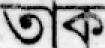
তাক
